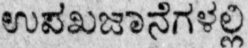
ಉಪಖಜಾನೆಗಳಲ್ಲಿ
